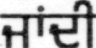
ਜਾਂਦੀ
